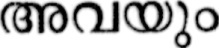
അവയും
